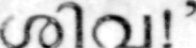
ശിവ!'
